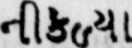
નીકળ્યા
